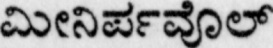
ಮೀನಿರ್ಪವೊಲ್
